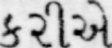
કરીએ
